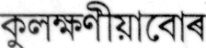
কুলক্ষণীয়াবোৰ
